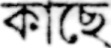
কাছে
